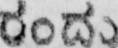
ರ೦ದು
